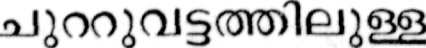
ചുററുവട്ടത്തിലുള്ള
